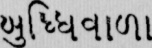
બુદિધવાળા
